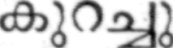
കുറച്ചു
